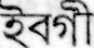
ইবগী
